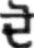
ਦੋ
